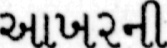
આખરની
